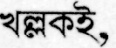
খল্লকই,
